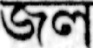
জল
